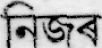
নিজৰ
